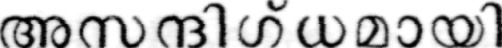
അസന്ദിഗ്ധമായി
